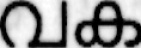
വക
